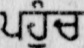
ਪਹੁੰਚ
